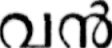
വന്‍
